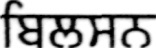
ਬਿਲਸਨ
